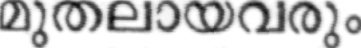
മുതലായവരും
